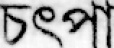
চৎপা
